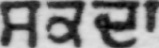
ਸਕਦਾ
